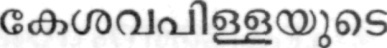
കേശവപിള്ളയുടെ
